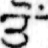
ਤੋਂ
